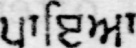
ਪਾਇਆ
